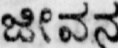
ಜೀವನ
